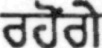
ਰਹੋਂਗੇ
